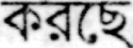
করছে
